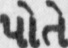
પોતે
